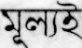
মূল্যই
